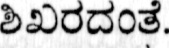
ಶಿಖರದಂತೆ.
